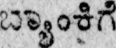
ಬ್ಯಾಂಕಿಗೆ
